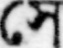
সে
